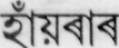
হাঁয়ৰাৰ
